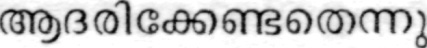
ആദരിക്കേണ്ടതെന്നു
